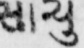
સાચુ
